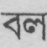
বল
